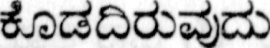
ಕೊಡದಿರುವುದು
